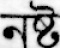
নষ্ট
